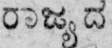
ರಾಜ್ಯದ
